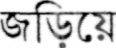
জড়িয়ে
